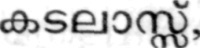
കടലാസ്സ്,
